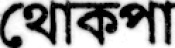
থোকপা
